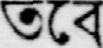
তবে
